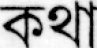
কথা
